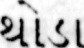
થોડા
